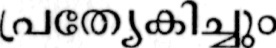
പ്രത്യേകിച്ചും
